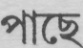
পাছে
